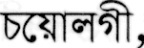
চয়োলগী,
